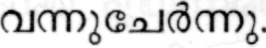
വന്നുചേര്‍ന്നു.
